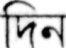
দিন
